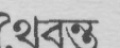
থৈবন্ত
